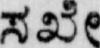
ಸಖೇ
